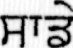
ਸਾਡੇ
